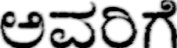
ಅವರಿಗೆ
